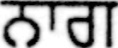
ਨਾਗ
